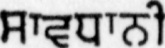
ਸਾਵਧਾਨੀ
